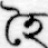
হৈ
